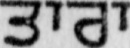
ਤਾਰਾ
